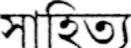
সাহিত্য
